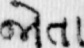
જોતા
